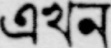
এখন
